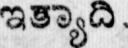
ಇತ್ಯಾದಿ.
